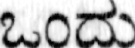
ಒಂದು
